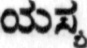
ಯಸ್ಯ
